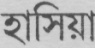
হাসিয়া
